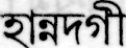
হান্নদগী
